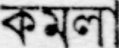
কমলা
